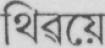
থিৱয়ে
